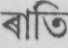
ৰাতি
